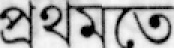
প্রথমতে
